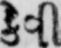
કેવી
